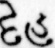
દેહ
